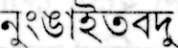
নুংঙাইতবদু
